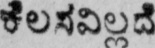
ಕೆಲಸವಿಲ್ಲದೆ
